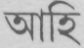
আহি
